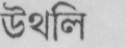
উথলি
